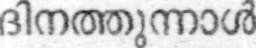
ദിനത്തുന്നാള്‍
